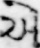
એ
